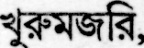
খুরুমজরি,
